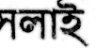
সলাই
